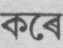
কৰে
